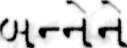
બન્નેને
